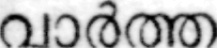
വാര്‍ത്ത
